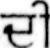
ਦੀ
